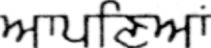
ਆਪਣਿਆਂ
